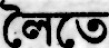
লৈতে
